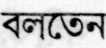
বলতেন
